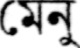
মেনু
